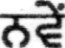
ਨਵੇਂ
